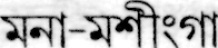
মনা-মশীংগা
